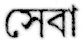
সেবা
